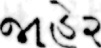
જાહેર
